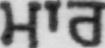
ਮਾਰ
